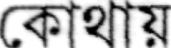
কোথায়
